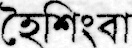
হৈশিংবা
